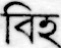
বিহ
